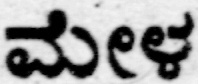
ಮೇಳ
